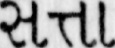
સત્ત
